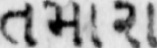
તમારા
